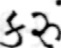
કરું
